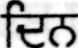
ਦਿਨ
